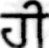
ਹੀ
